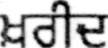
ਖ਼ਰੀਦ
